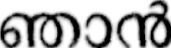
ഞാന്‍
